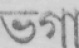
ভগা
